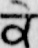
ਕੇ
